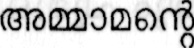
അമ്മാമന്റെ
